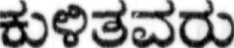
ಕುಳಿತವರು
